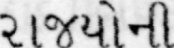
રાજ્યોની
